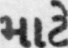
માટે
